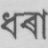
ধৰা
